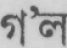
গ'ল
